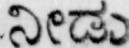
ನೀಡು
